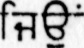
ਜਿਉਂ
